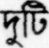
দুটি
